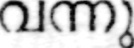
വന്നു
